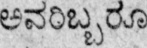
ಅವರಿಬ್ಬರೂ
